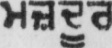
ਮਜ਼ਦੂਰ
